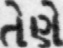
તેણે
